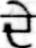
ਦੇ
